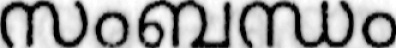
സംബന്ധം
